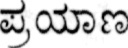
ಪ್ರಯಾಣ
